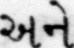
અને
